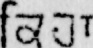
ਕਿਹਾ
